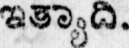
ಇತ್ಯಾದಿ.
